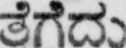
ತೆಗೆದು
